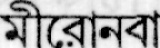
মীরোনবা
